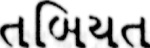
તબિયત
